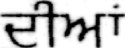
ਦੀਆਂ
